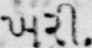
ખરી.
